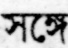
সঙ্গে
